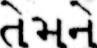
તેમને
